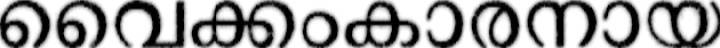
വൈക്കംകാരനായ
